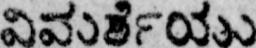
ವಿಮರ್ಶೆಯು
